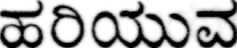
ಹರಿಯುವ
